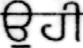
ਉਹੀ
